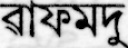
ৱাফমদু
